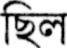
ছিল
